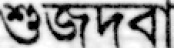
শুজদবা
